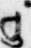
તું
